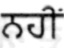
ਨਹੀਂ
